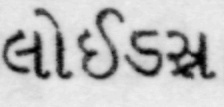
લોઈડસ્ર
